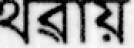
থৱায়
